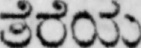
ತೆರೆಯ
